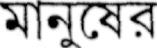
মানুষের
